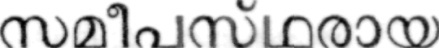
സമീപസ്ഥരായ
